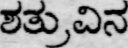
ಶತ್ರುವಿನ
